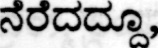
ನೆರೆದದ್ದೂ,
